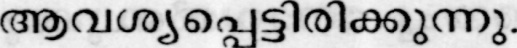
ആവശ്യപ്പെട്ടിരിക്കുന്നു.
